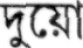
দুয়ো
